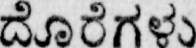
ದೊರೆಗಳು
